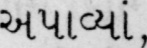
અપાવ્યાં,
